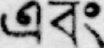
এবং
